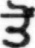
ਤੋਂ
